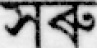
সৰু
